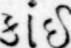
કાંઈ
